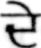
ਦੇ
